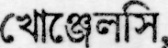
কোঞ্জেলসি,
